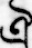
ঐ
